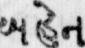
બહેન
